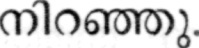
നിറഞ്ഞു.
